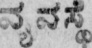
ವ್ಯವಸ್ಥೆ
